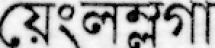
য়েংলম্লগা
